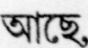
আছে,
